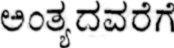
ಅಂತ್ಯದವರೆಗೆ
